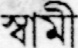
স্বামী
